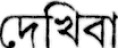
দেখিবা
